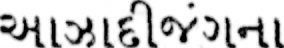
આઝાદીજંગના
